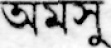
অমসু
